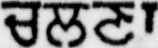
ਚਲਣਾ
